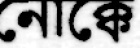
নোক্কে
